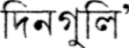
দিনগুলি’
